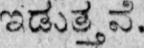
ಇಡುತ್ತವೆ.
